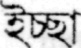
ইচ্ছা
